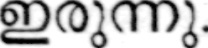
ഇരുന്നു.
